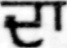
ਦਾ
